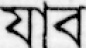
যাব
